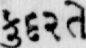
કુદરતે
